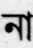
না
